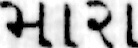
મારા
